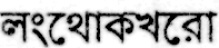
লংথোকখরো
